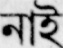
নাই
